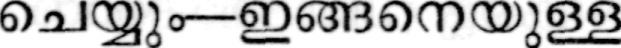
ചെയ്യും-ഇങ്ങനെയുള്ള
